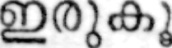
ഇരുകൂ
